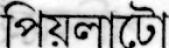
পিয়লাটো
